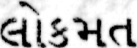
લોકમત
